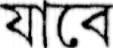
যাবে
